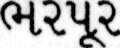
ભરપૂર
